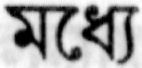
মধ্যে
